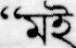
"মই
